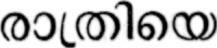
രാത്രിയെ
